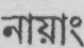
নায়াং
